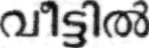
വീട്ടില്‍
